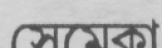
সেমেকা
